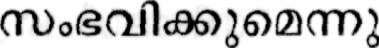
സംഭവിക്കുമെന്നു
